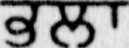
ਭਲਾ
